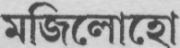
মজিলোহো
